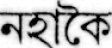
নহাকৈ
